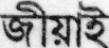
জীয়াই
